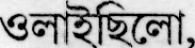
ওলাইছিলো,
